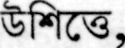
উশিত্তে,
